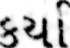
કર્યા
